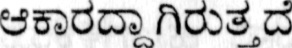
ಆಕಾರದ್ದಾಗಿರುತ್ತದೆ
